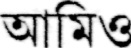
আমিও
